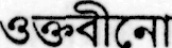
ওক্তবীনো
